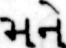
મને
